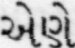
એણે
